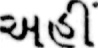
અહીં
